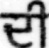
ਦੀ
